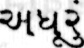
અધૂરું
